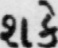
શકે
